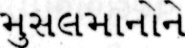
મુસલમાનોને
